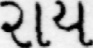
રાય
